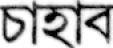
চাহাব
